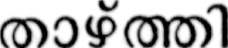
താഴ്ത്തി
